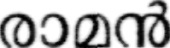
രാമന്‍
